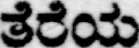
ತೆರೆಯ
